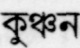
কুঞ্চন
